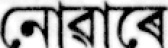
নোৱাৰে
